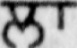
ਲਾ
